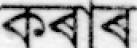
কৰাৰ
